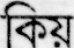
কিয়
